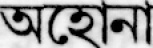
অহোনা
